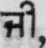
ਜੀ,
